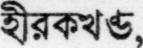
হীরকখন্ড,
